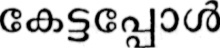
കേട്ടപ്പോള്‍
